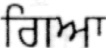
ਗਿਆ
